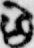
છે
